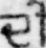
ਦੀ
